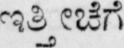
ಇತ್ತೀಚೆಗೆ
